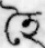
হৈ
